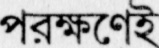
পরক্ষণেই
